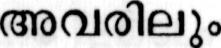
അവരിലും
